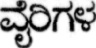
ವೈರಿಗಳ
